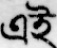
এই
